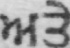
ਅਤੇ
